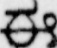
ಈ
